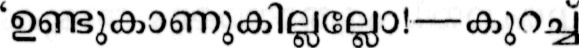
‘ഉണ്ടുകാണുകില്ലല്ലോ!-കുറച്ച്
